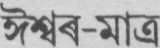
ঈশ্বৰ-মাত্ৰ
